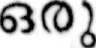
ഒരു
